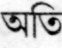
অতি
